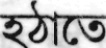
হঠাতে
